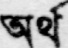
অর্থ
